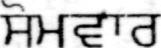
ਸੋਮਵਾਰ
